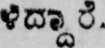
ಳಿದ್ದಾರೆ.
